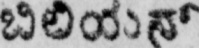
ಬಿಲಿಯನ್
